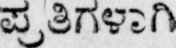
ಪ್ರತಿಗಳಾಗಿ
